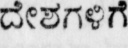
ದೇಶಗಳಿಗೆ
